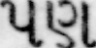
પણ
